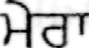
ਮੇਰਾ
